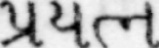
પ્રયત્ન
